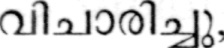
വിചാരിച്ചു,
